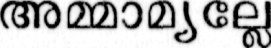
അമ്മാമ്യല്ലേ
